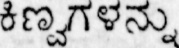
ಕಿಣ್ವಗಳನ್ನು
